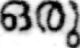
ഒരു
